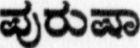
ಪುರುಷಾ
